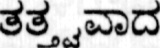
ತತ್ತ್ವವಾದ
